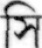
সি
